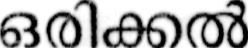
ഒരിക്കല്‍
